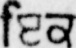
ਇਕ
